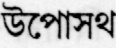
উপোসথ
